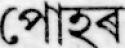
পোহৰ
